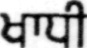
ਖਾਧੀ
